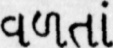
વળતાં
